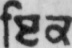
ਇਕ
